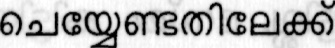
ചെയ്യേണ്ടതിലേക്ക്
